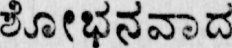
ಶೋಭನವಾದ
